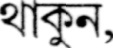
থাকুন,
